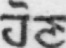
ਹੋਣ
